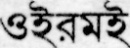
ওইরমই
